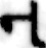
ન
